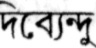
দিব্যেন্দু
